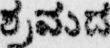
ಶ್ರಮದ
